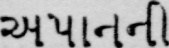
અપાનની
